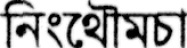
নিংথৌমচা
